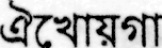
ঐখোয়গা
